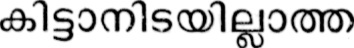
കിട്ടാനിടയില്ലാത്ത
